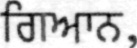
ਗਿਆਨ,
